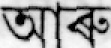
আৰু
